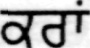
ਕਰਾਂ
